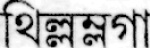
থিল্লম্লগা
